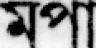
মপা
